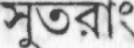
সুতরাং
